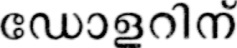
ഡോളറിന്
